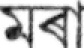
মৰা
